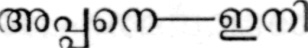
അപ്പനെ-ഇനി
